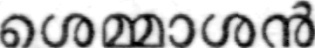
ശെമ്മാശന്‍
